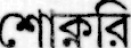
শোক্নিরি
